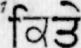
ਕਿਤੇ
